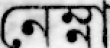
নেম্না
